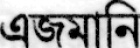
এজমানি
